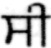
ਸੀ
